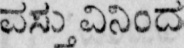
ವಸ್ತುವಿನಿಂದ
